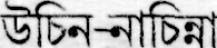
উচিন-নাচিন্না
